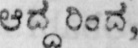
ಆದ್ದರಿಂದ,
